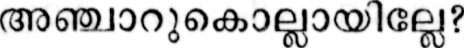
അഞ്ചാറുകൊല്ലായില്ലേ?
